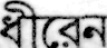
ধিরেন
